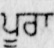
ਪੂਰਾ
